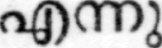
എന്നു
